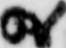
જ
